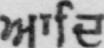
ਆਦਿ
